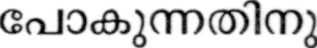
പോകുന്നതിനു
